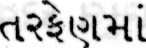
તરફેણમાં
